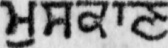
ਮੁਸਕਾਣ
